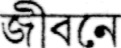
জীবনে
